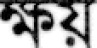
ক্ষয়
